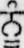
ਨੂੰ
